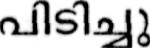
പിടിച്ചു
